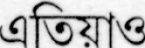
এতিয়াও
